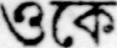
ওকে
